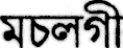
মচলগী
